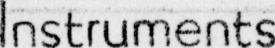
Instruments
